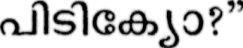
പിടിക്യോ?”
